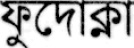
ফুদোক্না
